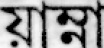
য়াম্না
